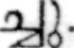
ച്ചു.
